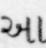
આ
